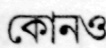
কোনও
